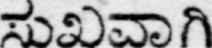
ಸುಖವಾಗಿ
